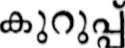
കുറുപ്പ്
